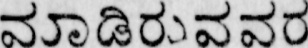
ಮಾಡಿರುವವರ
